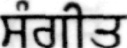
ਸੰਗੀਤ
